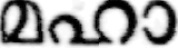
മഹാ
